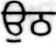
ਉਠ
